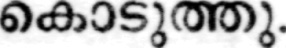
കൊടുത്തു.
